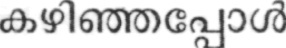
കഴിഞ്ഞപ്പോള്‍
